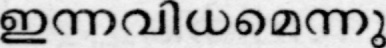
ഇന്നവിധമെന്നു
